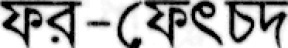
ফর-ফেৎচদ
